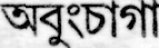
অবুংচাগা
